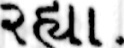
રહ્યા.
